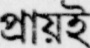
প্রায়ই
